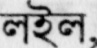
লইল,
